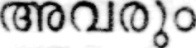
അവരും
